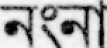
নংনা
